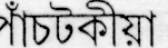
পাঁচটকীয়া
